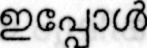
ഇപ്പോള്‍
